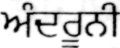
ਅੰਦਰੂਨੀ
